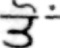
ਤੋਂ
